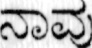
ನಾವು
